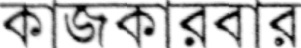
কাজকারবার
